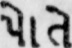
પોતે
